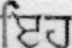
ਇਹ
